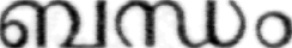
ബന്ധം
